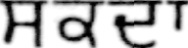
ਸਕਦਾ
